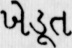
ખેડૂત
